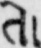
તો
